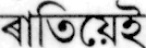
ৰাতিয়েই
